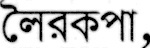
লৈরকপা,
